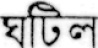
ঘটিল
